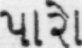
પારો
